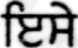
ਇਸੇ
